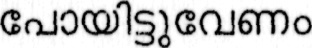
പോയിട്ടുവേണം
